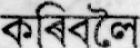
কৰিবলৈ
